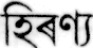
হিৰণ্য
